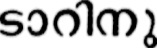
ടാറിനു
